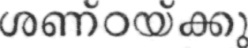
ശണ്ഠയ്ക്കു
